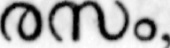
രസം,
